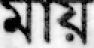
মায়
